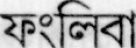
ফংলিবা
